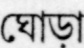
ঘোড়া
